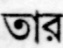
তার
